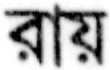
রায়
